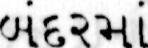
બંદરમાં
